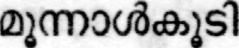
മൂന്നാള്‍കൂടി
